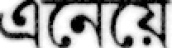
এনেয়ে
